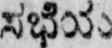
ಸಭೆಯ
